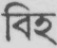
বিহ
